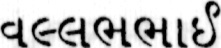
વલ્લભભાઈ
